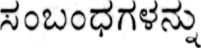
ಸಂಬಂಧಗಳನ್ನು
